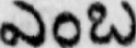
ಎಂಬ
